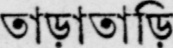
তাড়াতাড়ি
